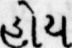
હોય
